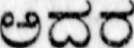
ಅದರ
